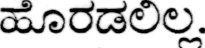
ಹೊರಡಲಿಲ್ಲ.
